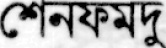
শেনফমদু
